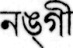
নঙগী
